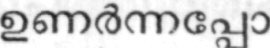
ഉണര്‍ന്നപ്പോ
